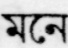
মনে
